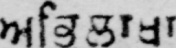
ਅਭਿਲਾਖਾ
